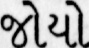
જોયો
